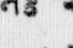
અનેક
